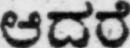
ಆದರೆ
